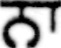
ਨਾ
